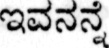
ಇವನನ್ನೆ
